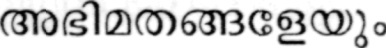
അഭിമതങ്ങളേയും
